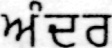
ਅੰਦਰ
